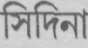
সিদিনা
